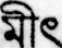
মীৎ
